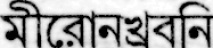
মীরোনখ্রবনি
